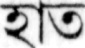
হাত
